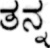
ತನ್ನ
